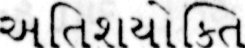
અતિશયોક્તિ
